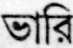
ভারি
